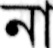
না
